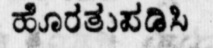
ಹೊರತುಪಡಿಸಿ
